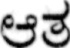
ಆತ
